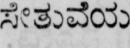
ಸೇತುವೆಯ
